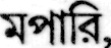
মপারি,
